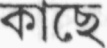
কাছে
